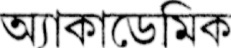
অ্যাকাডেমিক
